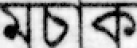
মচাক
